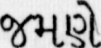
જમણે
